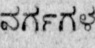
ವರ್ಗಗಳ
